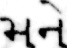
મને
